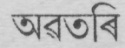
অৱতৰি
